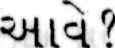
આવે?
